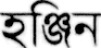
হঞ্জিন
